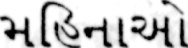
મહિનાઓ
